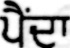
ਪੈਂਦਾ
